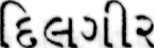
દિલગીર
